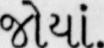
જોયાં.
